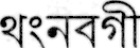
থংনবগী
